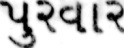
પુરવાર
